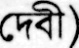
দেবী)
